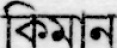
কিমান
